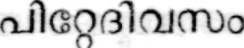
പിറ്റേദിവസം
